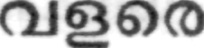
വളരെ
